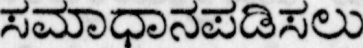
ಸಮಾಧಾನಪಡಿಸಲು
